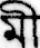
মী
